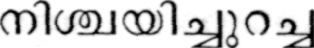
നിശ്ചയിച്ചുറച്ച
